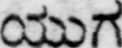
ಯುಗ
